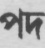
পদ
